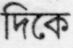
দিকে
